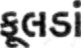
ફૂલડાં
